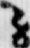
કે
